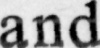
and
